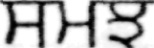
ਸਮਝ
